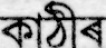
কাঠীৰ
